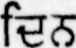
ਦਿਨ
